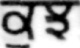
ਕੁਝ
